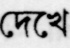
দেখে
